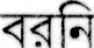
বরনি
